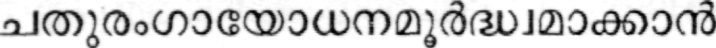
ചതുരംഗായോധനമൂര്‍ദ്ധ്വമാക്കാന്‍
